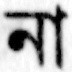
না
